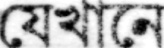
যেখানে
